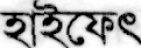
হাইফেৎ
